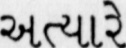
અત્યારે
